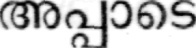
അപ്പാടെ
